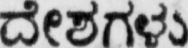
ದೇಶಗಳು
